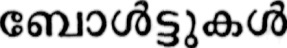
ബോള്‍ട്ടുകള്‍
